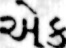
એક
